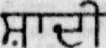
ਸ਼ਾਦੀ
